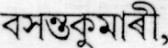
বসন্তকুমাৰী,
